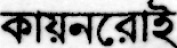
কায়নরোই
